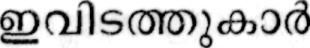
ഇവിടത്തുകാര്‍
